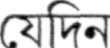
যেদিন
